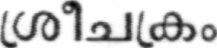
ശ്രീചക്രം
